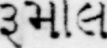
રૂમાલ
